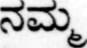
ನಮ್ಮ
